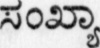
ಸಂಖ್ಯಾ
